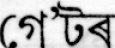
গে'টৰ
